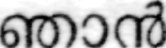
ഞാന്‍
